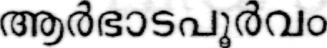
ആര്‍ഭാടപൂര്‍വം
